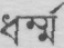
ধৰ্ম্ম
